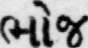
ભોજ
